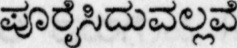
ಪೂರೈಸಿದುವಲ್ಲವೆ
